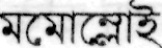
মমোম্লোই
